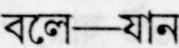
বলে–যান
